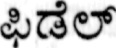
ಫಿಡೆಲ್
